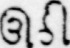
ઊઠી
